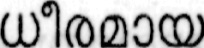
ധീരമായ
